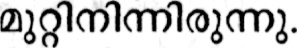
മുറ്റിനിന്നിരുന്നു.
